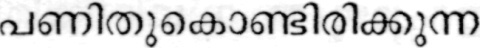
പണിതുകൊണ്ടിരിക്കുന്ന
